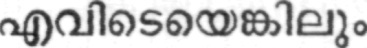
എവിടെയെങ്കിലും
